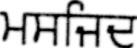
ਮਸਜਿਦ
